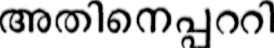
അതിനെപ്പററി
